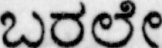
ಬರಲೇ
